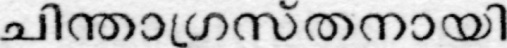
ചിന്താഗ്രസ്തനായി
